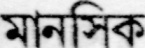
মানসিক
